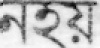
নহয়
